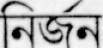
নির্জন
